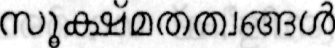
സൂക്ഷ്മതത്വങ്ങള്‍
